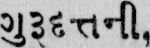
ગુરૂદત્તની,
